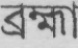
ব্ৰহ্মা
